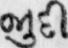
જુદી
